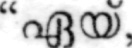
“ഏയ്,
